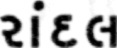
રાંદલ
